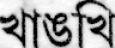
খাঙখি
